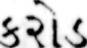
કરોડ
